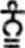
ਨੂੰ
